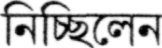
নিচ্ছিলেন
